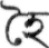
হৈ
